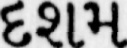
દશમ
